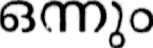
ഒന്നും
